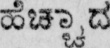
ಹೆಚ್ಚಾದ
